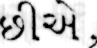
છીએ,
